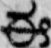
ಈ
